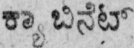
ಕ್ಯಾಬಿನೆಟ್
